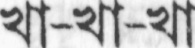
খা-খা-খা
